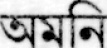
অমনি
